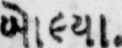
બોલ્યા.
